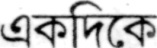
একদিকে
